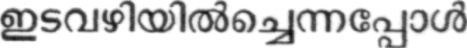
ഇടവഴിയില്‍ച്ചെന്നപ്പോള്‍
